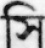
সি
